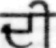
ਦੀ
